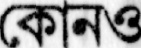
কোনও
